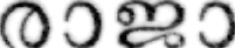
രാജാ
